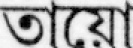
তায়ো
